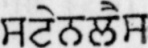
ਸਟੇਨਲੈਸ
